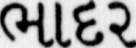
ભાદર
